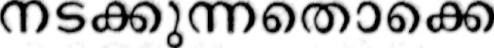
നടക്കുന്നതൊക്കെ
